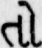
તો
